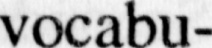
vocabu-
